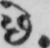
છે.
